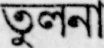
তুলনা
